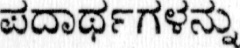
ಪದಾರ್ಥಗಳನ್ನು
